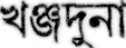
খঞ্জদুনা
